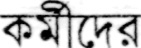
কর্মীদের
